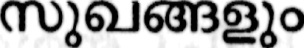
സുഖങ്ങളും
